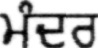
ਮੰਦਰ
